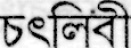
চৎলিবী
